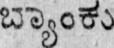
ಬ್ಯಾಂಕು
